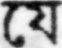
যে
